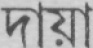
দায়া
